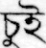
চুই
